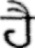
ਹੈ
